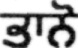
ਭਾਨੋ
